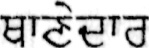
ਥਾਣੇਦਾਰ
